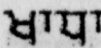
ਖਾਧਾ
